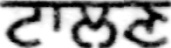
ਟਾਲਣ
